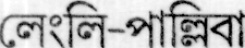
লেংলি-পাল্লিবা
